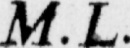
M.L.
